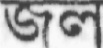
জল
